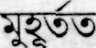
মুহূর্তত
